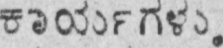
ಕಾರ್ಯಗಳು.
